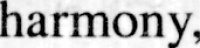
harmony,
